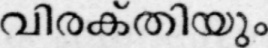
വിരക്തിയും
